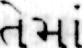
તેમાં
